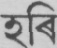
হৰি
